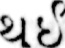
થઈ
